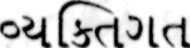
વ્યક્તિગત
